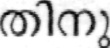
തിനു
